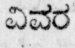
ವಿವರ
